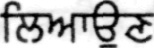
ਲਿਆਉਣ
